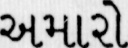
અમારો
